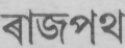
ৰাজপথ
